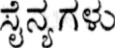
ಸೈನ್ಯಗಳು
